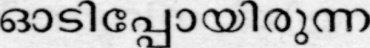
ഓടിപ്പോയിരുന്ന
